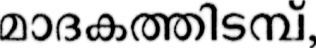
മാദകത്തിടമ്പ്,
